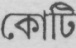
কোটি
